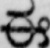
ಈ
